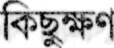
কিছুক্ষণ
